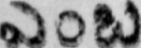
ಎಂಬ
